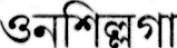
ওনশিল্লগা
